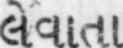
લેવાતા
